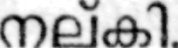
നല്കി.
